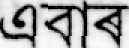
এবাৰ
